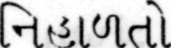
નિહાળતો
